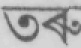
তৰু
